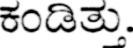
ಕಂಡಿತ್ತು.
